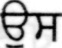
ਉਸ
